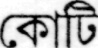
কোটি
